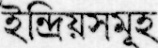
ইন্দ্রিয়সমূহ
